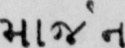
માર્જન
